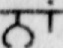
ਨਾਂ
